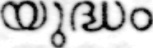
യുദ്ധം
